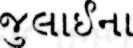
જુલાઈના
